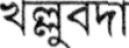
খল্লুবদা
